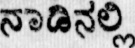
ನಾಡಿನಲ್ಲಿ
